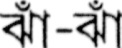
ঝাঁ-ঝাঁ
